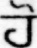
ਹੋ
